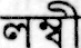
লম্বী
